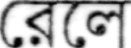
রেলে
